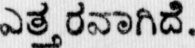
ಎತ್ತರವಾಗಿದೆ.
